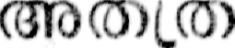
അതത്ര
